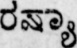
ರಷ್ಯಾ
